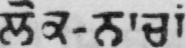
ਲੋਕ-ਨਾਚਾਂ
